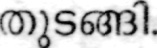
തുടങ്ങി.
